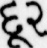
દૂર
